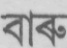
বাৰু
